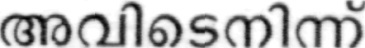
അവിടെനിന്ന്
